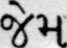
જેમ
